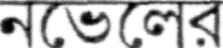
নভেলের
